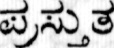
ಪ್ರಸ್ತುತ
